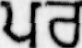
ਪਰ
